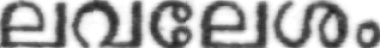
ലവലേശം
